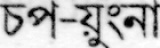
চপ-য়ুংনা
